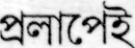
প্রলাপেই
